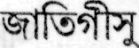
জাতিগীসু
